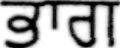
ਭਾਗ
